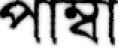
পাম্বা
